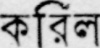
করিল
